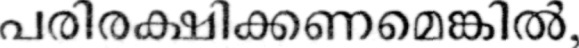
പരിരക്ഷിക്കണമെങ്കില്‍,
